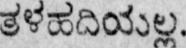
ತಳಹದಿಯಲ್ಲ.
